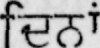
ਦਿਨਾਂ
